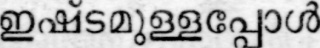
ഇഷ്ടമുള്ളപ്പോള്‍
